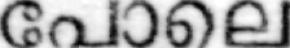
പോലെ
